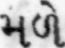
મળે
